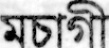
মচাগী
